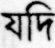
যদি
